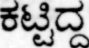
ಕಟ್ಟಿದ್ದ
